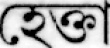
হেক্তা
